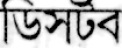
ডিসর্টব
